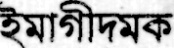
ইমাগীদমক
